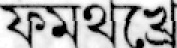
ফমথখ্রে
